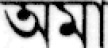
অমা
